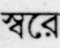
স্বরে
